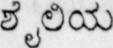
ಶೈಲಿಯ
